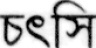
চৎসি
